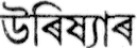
উৰিষ্যাৰ
